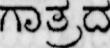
ಗಾತ್ರದ
